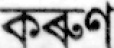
কৰুণ
